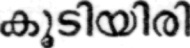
കൂടിയിരി
